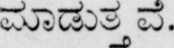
ಮಡುತ್ತವೆ.
